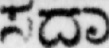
ಸದಾ
